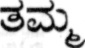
ತಮ್ಮ
